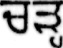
ਚੜ੍ਹ
